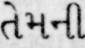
તેમની
